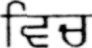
ਵਿਚ
